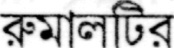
রুমালটির
